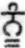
ਨੂੰ
